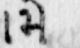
મે
